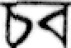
চব
